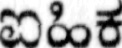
ಐಹಿಕ
